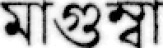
মাগুম্বা
